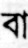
বা
